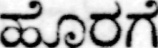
ಹೊರಗೆ
